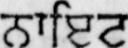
ਨਾਇਟ
